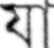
যা
